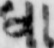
ઘા
